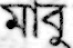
মাবু
